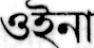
ওইনা
